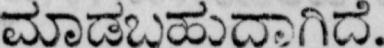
ಮಾಡಬಹುದಾಗಿದೆ.
